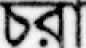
চরা
